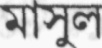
মাসুল
